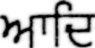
ਆਦਿ
